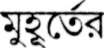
মুহূর্তের
